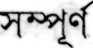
সম্পূর্ণ
